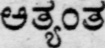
ಅತ್ಯಂತ
